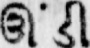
ઊંડી
